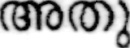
അതു
